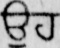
ਉਹ
